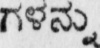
ಗಳನ್ನು
